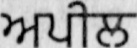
ਅਪੀਲ
